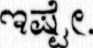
ಇಷ್ಟೇ.
